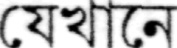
যেখানে
